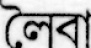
লৈবা
